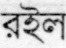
রইল
